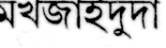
মখজাইদুদা
